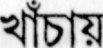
খাঁচায়
